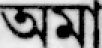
অমা
